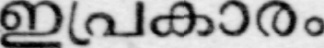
ഇപ്രകാരം
